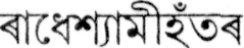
ৰাধেশ্যামীহঁতৰ
